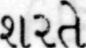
શરતે
